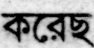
করেছ
